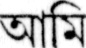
আমি
